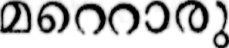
മറെറാരു
